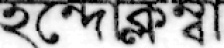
হন্দোক্লম্বা
